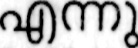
എന്നു
